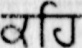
ਕਹਿ
